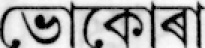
ভোকোৰা
